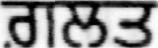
ਗ਼ਲਤ
